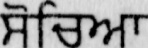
ਸੋਚਿਆ
